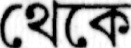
থেকে
